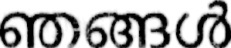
ഞങ്ങള്‍
